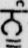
ਨੂੰ
